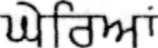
ਘੇਰਿਆਂ
